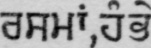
ਰਸਮਾਂ,ਹੰਭੇ
